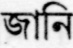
জানি
